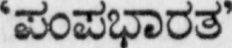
‘ಪಂಪಭಾರತ’
